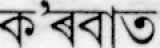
ক'ৰবাত
